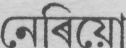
নেৰিয়ো
